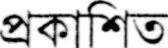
প্রকাশিত
